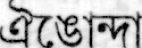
ঐঙোন্দা
